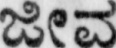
ಜೀವ
